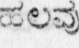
ಹಲವು
